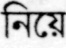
নিয়ে
